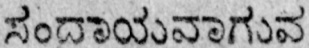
ಸಂದಾಯವಾಗುವ
